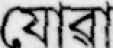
যোৱা
